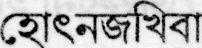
হোৎনজখিবা
